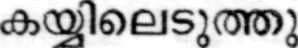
കയ്യിലെടുത്തു
